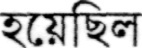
হয়েছিল
